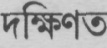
দক্ষিণত
